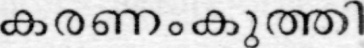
കരണംകുത്തി
